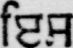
ਇਸ
